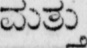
ಮತ್ತು
